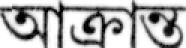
আক্রান্ত
